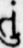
તું
